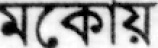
মকোয়
